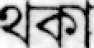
থকা
